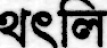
থৎলি
